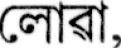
লোৱা,
